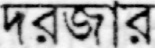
দরজার
